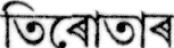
তিৰোতাৰ
